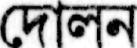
দোলন
